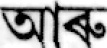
আৰু
